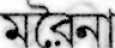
মরৈনা
